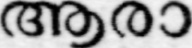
ആരാ
